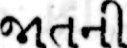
જાતની
